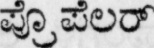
ಪ್ರೊಪೆಲರ್
